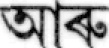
আৰু
